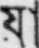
যা
